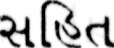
સહિત
